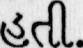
હતી.
